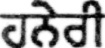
ਹਨੇਰੀ
